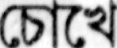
চোখে
